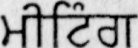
ਮੀਟਿੰਗ
